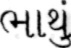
ભાથું
